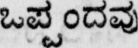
ಒಪ್ಪಂದವು
